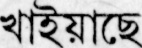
খাইয়াছে
